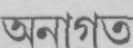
অনাগত
